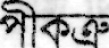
পীকক্র
